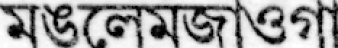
মঙলেমজাওগা
